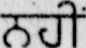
ਨਹੀਂ
